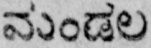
ಮಂಡಲ
